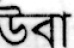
উবা
